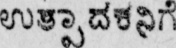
ಉತ್ಪಾದಕನಿಗೆ
